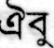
ঐবু
